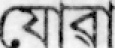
যোৱা
